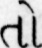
તો
